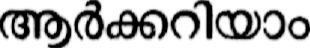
ആര്‍ക്കറിയാം
